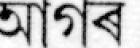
আগৰ
